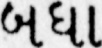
બધા
